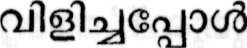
വിളിച്ചപ്പോള്‍
